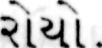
રોયો.
